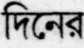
দিনের
